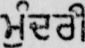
ਮੁੰਦਰੀ
